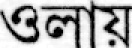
ওলায়
